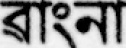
ৱাংনা
